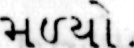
મળ્યો.
